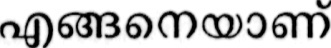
എങ്ങനെയാണ്
